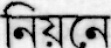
নিয়নে
